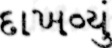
દાખવ્યું
